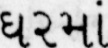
ઘરમાં
